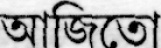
আজিতো
